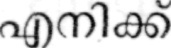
എനിക്ക്
